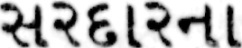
સરદારના
